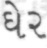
ઘેર
